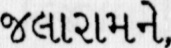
જલારામને,
